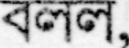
বলল,
